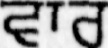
ਵਾਰ
